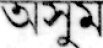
অসুম
